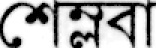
শেম্লবা
